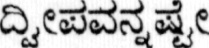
ದ್ವೀಪವನ್ನಷ್ಟೇ
